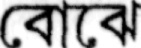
বোঝে
